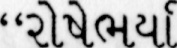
"રોષેભર્યા
